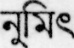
নুমিৎ
